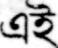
এই
